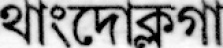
থাংদোক্লগা
